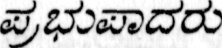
ಪ್ರಭುಪಾದರು
